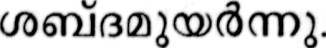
ശബ്ദമുയര്‍ന്നു.
